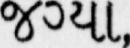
જગ્યા,
